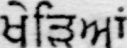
ਖੇੜਿਆਂ
